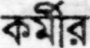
কর্মীর
